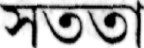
সততা
